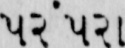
પરંપરા
